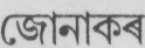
জোনাকৰ
